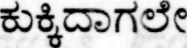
ಕುಕ್ಕಿದಾಗಲೇ
